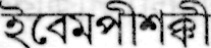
ইবেমপীশক্কী
